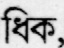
ধিক,
